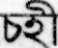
চহী
